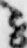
કે
